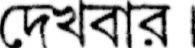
দেখবার।
